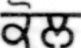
ਕੋਲ
